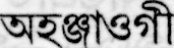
অহঞ্জাওগী
